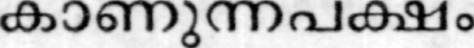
കാണുന്നപക്ഷം
